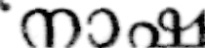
‘നാഷ
